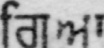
ਗਿਆ
